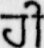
ਹੀ
